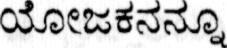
ಯೋಜಕನನ್ನೂ
